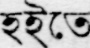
হইতে
